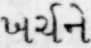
ખર્ચને
